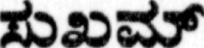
ಸುಖಮ್
